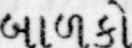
બાળકો
